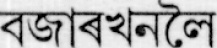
বজাৰখনলৈ
